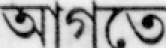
আগতে
